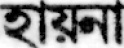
হায়না
